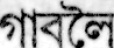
গাবলৈ
